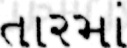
તારમાં
